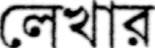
লেখার
